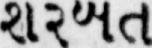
શરબત
